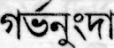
গর্ভনুংদা
